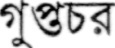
গুপ্তচর
